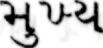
મુખ્ય
